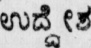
ಉದ್ದೇಶ
